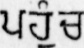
ਪਹੁੰਚ
